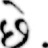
છે.
